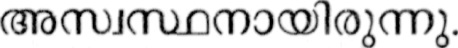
അസ്വസ്ഥനായിരുന്നു.
